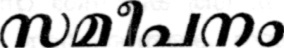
സമീപനം
